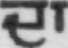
ਦਾ
